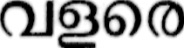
വളരെ
